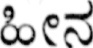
ಹೀನ
